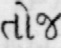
તોજ
